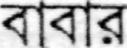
বাবার
